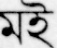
মই
